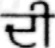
ਦੀ
